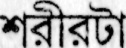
শরীরটা
